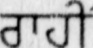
ਰਾਹੀਂ
